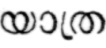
യാത്ര
